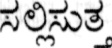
ಸಲ್ಲಿಸುತ್ತ
